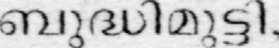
ബുദ്ധിമുട്ടി,
